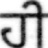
ਹੀ
